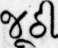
જૂઠી
